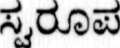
ಸ್ವರೂಪ
